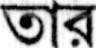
তার
